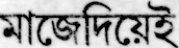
মাজেদিয়েই
